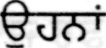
ਉਹਨਾਂ
